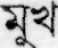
মুখ
